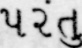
પરંતુ
